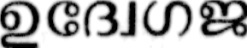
ഉദ്വേഗജ
